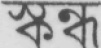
স্কন্ধ
